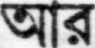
আর
